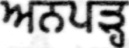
ਅਨਪੜ੍ਹ
